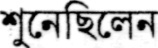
শুনেছিলেন
